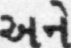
અને
